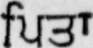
ਪਿਤਾ
